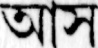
আস
